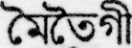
মৈতৈগী
